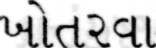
ખોતરવા
